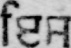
ਇਸ
